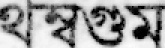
থম্বগুম
